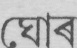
ঘোৰ
